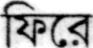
ফিরে
